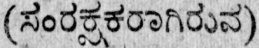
(ಸಂರಕ್ಷಕರಾಗಿರುವ)
